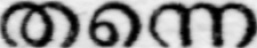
തന്നെ
